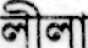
লীলা
